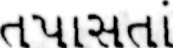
તપાસતાં
